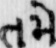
તમે
